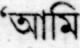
‘আমি
